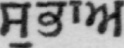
ਸੁਭਾਅ
